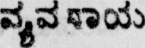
ವ್ಯವಸಾಯ
